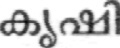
കൃഷി
